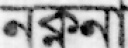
নক্ননা
